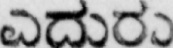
ಎದುರು
